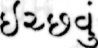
ઈચ્છવું
